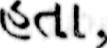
હતા,
